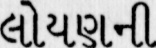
લોયણવી
